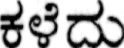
ಕಳೆದು
